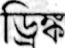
ড্রিঙ্ক
